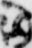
છે
